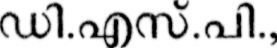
ഡി.എസ്.പി.,
